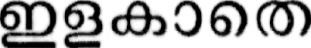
ഇളകാതെ
